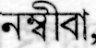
নম্বীবা,
